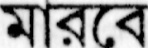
মারবে
